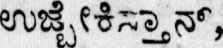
ಉಜ್ಬೇಕಿಸ್ತಾನ್,
